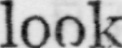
look
